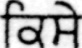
ਕਿਸੇ
